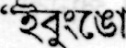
“ইবুংঙো
